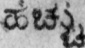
ಹೆಚ್ಚು
